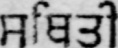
ਸਥਿਤੀ
